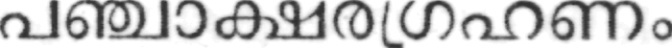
പഞ്ചാക്ഷരഗ്രഹണം
